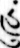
હું
